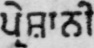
ਪ੍ਰੇਸ਼ਾਨੀ
